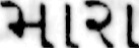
મારા
